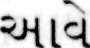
આવે
